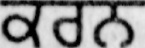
ਕਰਨ
